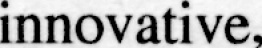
innovative,
